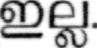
ഇല്ല.
